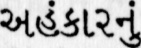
અહંકારનું
